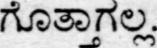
ಗೊತ್ತಾಗಲ್ಲ.
